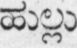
ಹುಲ್ಲು
